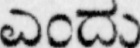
ಎಂದು
